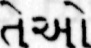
તેઓ
